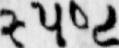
સ્પષ્ટ
